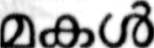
മകള്‍
